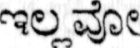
ಇಲ್ಲವೋ
